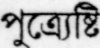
পুত্র্যেষ্টি
